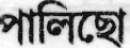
পালিছো
